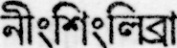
নীংশিংলিব্রা
